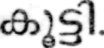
കൂട്ടി.
